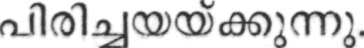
പിരിച്ചയയ്ക്കുന്നു.
